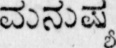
ಮನುಷ್ಯ
